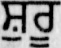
ਸ਼ੁਰੂ
